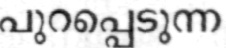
പുറപ്പെടുന്ന
